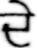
ਦੇ
